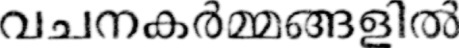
വചനകര്‍മ്മങ്ങളില്‍
